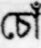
চোঁ
